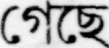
গেছে
